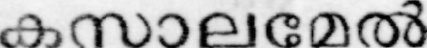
കസാലമേല്‍
